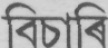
বিচাৰি
